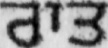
ਰਾਤ
